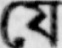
যে
